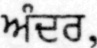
ਅੰਦਰ,
